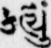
કહ્યું
